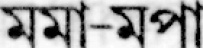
মমা-মপা
